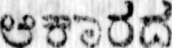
ಆಕಾರದ
